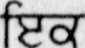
ਇਕ
